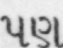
પણ
